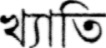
খ্যাতি
